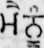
ਮੈਨੂੰ
